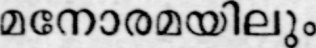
മനോരമയിലും
